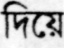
দিয়ে
